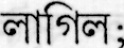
লাগিল;
